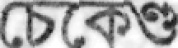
চেকেণ্ড
